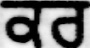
ਕਰ
